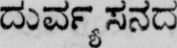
ದುರ್ವ್ಯಸನದ
